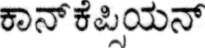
ಕಾನ್ಕೆಪ್ಸಿಯನ್
